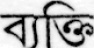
ব্যক্তি
